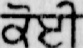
ਕੋਈ
